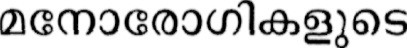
മനോരോഗികളുടെ
